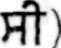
ਸੀ)
